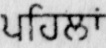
ਪਹਿਲਾਂ
